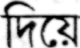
দিয়ে
